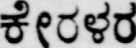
ಕೇರಳರ
